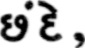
છંદે,
